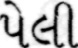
પેલી
